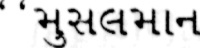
"મુસલમાન
